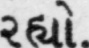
રહ્યો.
